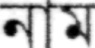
নাম
